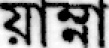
য়াম্না
